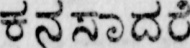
ಕನಸಾದರೆ
